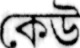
কেউ
